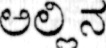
ಅಲ್ಲಿನ
